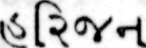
હરિજન
